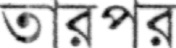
তারপর
